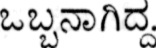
ಒಬ್ಬನಾಗಿದ್ದ.
